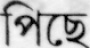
পিছে
